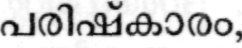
പരിഷ്കാരം,
